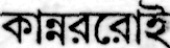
কান্নররোই
